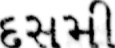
દસમી
